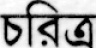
চরিত্র
